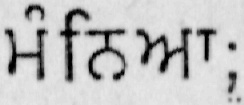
ਮੰਨਿਆ;
